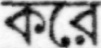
করে
